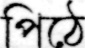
পিঠে
